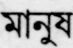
মানুষ
